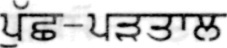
ਪੁੱਛ-ਪੜਤਾਲ
